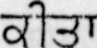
ਕੀਤਾ
